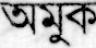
অমুক
